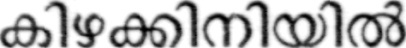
കിഴക്കിനിയില്‍
